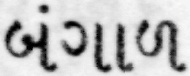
બંગાળ
